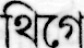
থিগে
